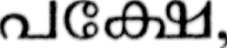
പക്ഷേ,
